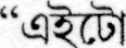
"এইটো
